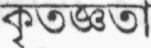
কৃতজ্ঞতা
